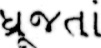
ધ્રૂજતાં
